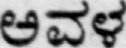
ಅವಳ
